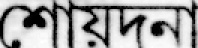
শোয়দনা
